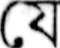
যে
